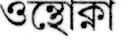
ওন্থোক্না
